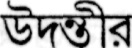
উদন্তীর
